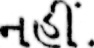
નહીં.
